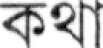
কথা
